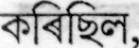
কৰিছিল,
